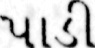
પાડી
